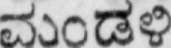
ಮಂಡಳಿ
